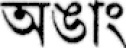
অঙাং
